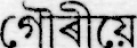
গৌৰীয়ে
